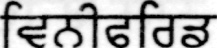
ਵਿਨੀਫਰਿਡ
